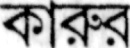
কারুর
